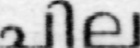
ചില
